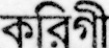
করিগী
